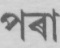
পৰা
